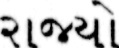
રાજ્યો
